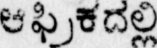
ಆಫ್ರಿಕದಲ್ಲಿ
